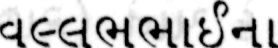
વલ્લભભાઈના
